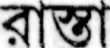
রাস্তা
